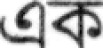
এক
